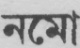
নমো
